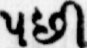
પછી
